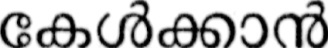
കേള്‍ക്കാന്‍
